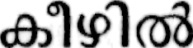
കീഴില്‍
